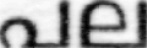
പല
